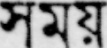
সময়
